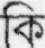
কি
